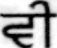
ਵੀ
